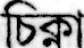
চিক্না
